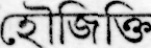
হৌজিক্তি
